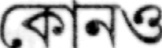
কোনও
